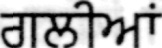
ਗਲੀਆਂ
